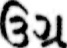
ઉગ્ર
